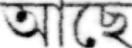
আছে
